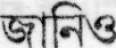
জানিও
